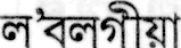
ল'বলগীয়া
